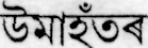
উমাহঁতৰ
